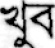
খুব
